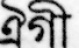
ঐগী
